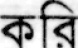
করি
